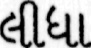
લીધા
